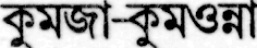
কুমজা-কুমওন্না
